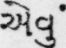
એવું
